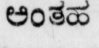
ಅಂತಹ
